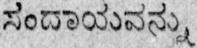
ಸಂದಾಯವನ್ನು
